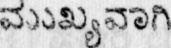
ಮುಖ್ಯವಾಗಿ
